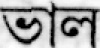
ভাল
